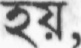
হয়,
